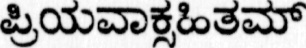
ಪ್ರಿಯವಾಕ್ಸಹಿತಮ್
